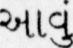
આવું
